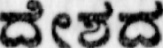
ದೇಶದ
